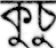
কুচু
